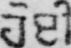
ਹੋਈ
